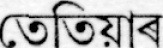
তেতিয়াৰ
